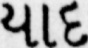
યાદ
